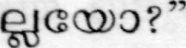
ല്ലയോ?"
